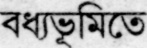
বধ্যভূমিতে
